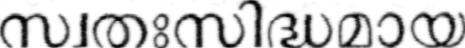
സ്വതഃസിദ്ധമായ
